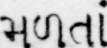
મળતાં
